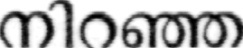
നിറഞ്ഞ
